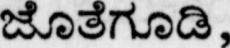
ಜೊತೆಗೂಡಿ,
